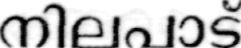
നിലപാട്
